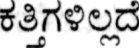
ಕತ್ತಿಗಳಿಲ್ಲದೆ
